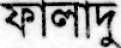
ফালাদু
